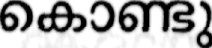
കൊണ്ടു
